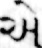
એ
